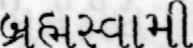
બ્રહ્મસ્વામી
